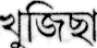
খুজিছা
